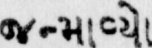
જન્માવ્યો
